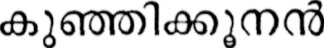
കുഞ്ഞിക്കൂനന്‍
